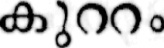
കുററം
